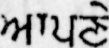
ਆਪਣੇ
